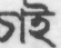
চাই
